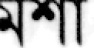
মশা
